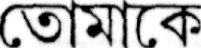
তোমাকে
